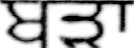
ਬੜਾ
